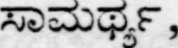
ಸಾಮರ್ಥ್ಯ,
